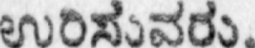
ಉರಿಸುವರು.
